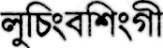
লুচিংবশিংগী
